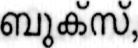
ബുക്സ്,
